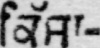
ਕਿੱਸਾ-
